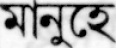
মানুহে
